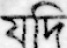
যদি
